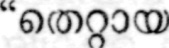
“തെറ്റായ
